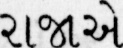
રાજાએ
